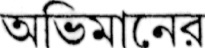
অভিমানের
